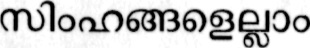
സിംഹങ്ങളെല്ലാം
